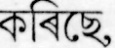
কৰিছে,
